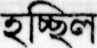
হচ্ছিল
